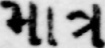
માત્ર
